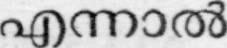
എന്നാല്‍
